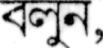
বলুন,
